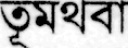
তূমথবা
